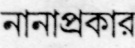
নানাপ্রকার
